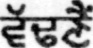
ਵੱਢਣੈਂ
